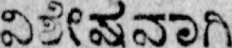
ವಿಶೇಷವಾಗಿ
